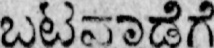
ಬಟವಾಡೆಗೆ
